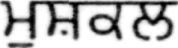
ਮੁਸ਼ਕਲ
